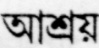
আশ্রয়
